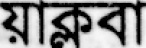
য়াক্লবা
